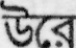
উরে
